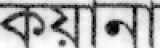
কয়ানা
